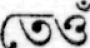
তেওঁ
